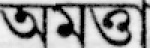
অমত্তা
